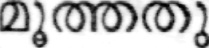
മൂത്തതു
